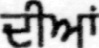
ਦੀਆਂ
